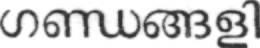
ഗണ്ഡങ്ങളി
